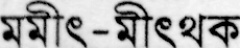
মমীৎ-মীৎথক
